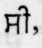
ਸੀ,
